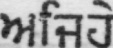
ਅਜਿਹੇ
